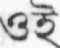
ওই
